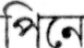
পিনে
